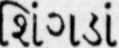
શિંગડાં
